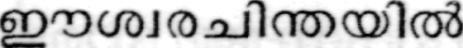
ഈശ്വരചിന്തയില്‍
